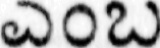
ಎಂಬ
